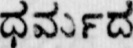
ಧರ್ಮದ
